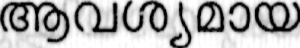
ആവശ്യമായ
